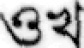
ওখ
